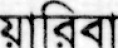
য়ারিবা
